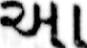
આ
